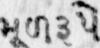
મૂળરૂપે
